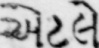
એટલે
